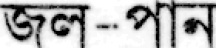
জল-পান
